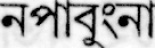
নপাবুংনা
